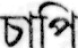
চাপি
